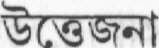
উত্তেজনা
